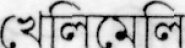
খেলিমেলি
